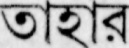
তাহার
